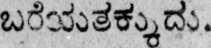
ಬರೆಯತಕ್ಕುದು.
